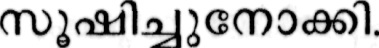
സൂഷിച്ചുനോക്കി.
